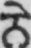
ਨੇ
